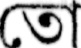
তো
